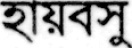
হায়বসু
